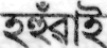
হহুঁৱাই
